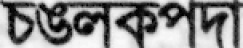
চঙলকপদা
